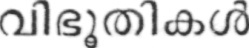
വിഭൂതികള്‍
